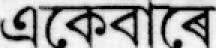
একেবাৰে
